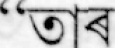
"তাৰ
